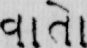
વાતો
